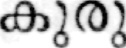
കുരു
